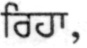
ਰਿਹਾ,
